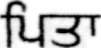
ਪਿਤਾ
